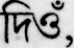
দিওঁ,
